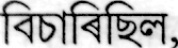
বিচাৰিছিল,
